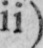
ii)
